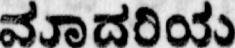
ಮಾದರಿಯ
